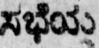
ಸಭೆಯ
